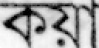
কয়া
